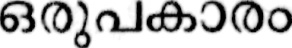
ഒരുപകാരം
